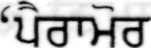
'ਪੈਰਾਮੋਰ
